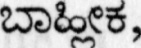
ಬಾಹ್ಲೀಕ,
